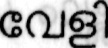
വേളി
